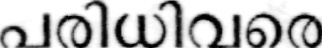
പരിധിവരെ
